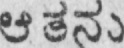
ಆತನು
